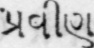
પ્રવીણ
